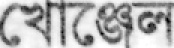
খোঞ্জেল
